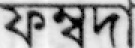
ফম্বদা
